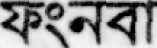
ফংনবা
